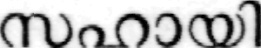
സഹായി
